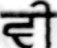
ਵੀ
